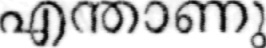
എന്താണു
